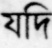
যদি
